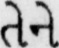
તેને
